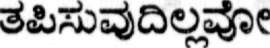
ತಪಿಸುವುದಿಲ್ಲವೋ
